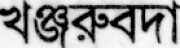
খঞ্জরুবদা
